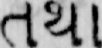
તથા
